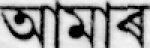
আমাৰ
